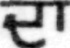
ਦਾ
